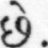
છે.
